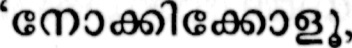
‘നോക്കിക്കോളൂ,
